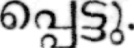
പ്പെട്ടു.
